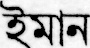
ইমান
